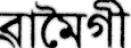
ৱামৈগী
